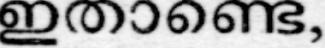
ഇതാണ്ടെ,
